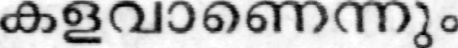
കളവാണെന്നും
